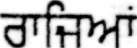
ਰਾਜਿਆਂ
